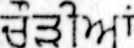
ਚੌੜੀਆਂ
